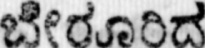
ಬೇರೂರಿದ
